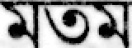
মতম
